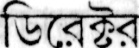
ডিরেক্টর
